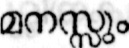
മനസ്സും
